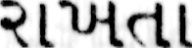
રાખતા
